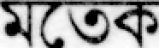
মতেক
